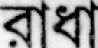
রাধা
